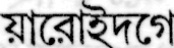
য়ারোইদগে
